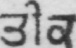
ਤੀਕ
